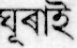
ঘূৰাই
